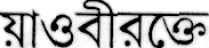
য়াওবীরক্তে
